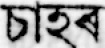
চাহৰ
